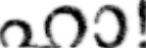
ഹാ!
